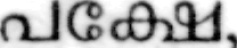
പക്ഷേ,
